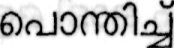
പൊന്തിച്ച്
